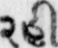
રહી
